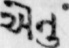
એનું
